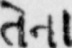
તેના
